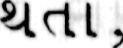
થતા,
